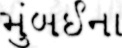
મુંબઇના
